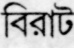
বিরাট
